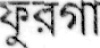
ফুরগা
